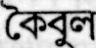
কৈবুল
